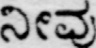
ನೀವು
